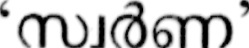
'സ്വര്‍ണ'
